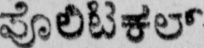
ಪೊಲಿಟಿಕಲ್
